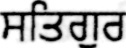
ਸਤਿਗੁਰ
